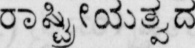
ರಾಷ್ಟ್ರೀಯತ್ವದ
